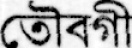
তৌবগী
